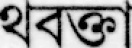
থবক্তা
